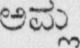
ಆಮ್ಲ
